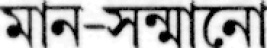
মান-সন্মানো
